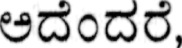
ಅದೆಂದರೆ,
